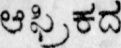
ಆಫ್ರಿಕದ
